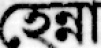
হেন্না
